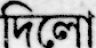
দিলো
